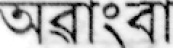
অৱাংবা
